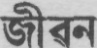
জীৱন
